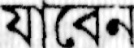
যাবেন
